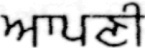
ਆਪਣੀ
